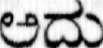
ಅದು
